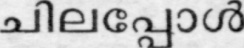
ചിലപ്പോള്‍
